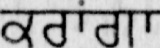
ਕਰਾਂਗਾ
